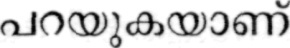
പറയുകയാണ്
